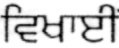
ਵਿਖਾਈਂ
